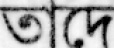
তাদে
